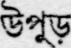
উপুড়
